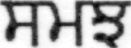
ਸਮਝ
